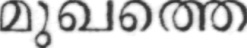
മുഖത്തെ
